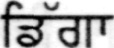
ਡਿੱਗਾ
